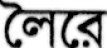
লৈরে
